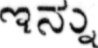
ಇನ್ನು
